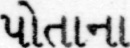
પોતાના
